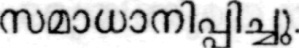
സമാധാനിപ്പിച്ചു.
